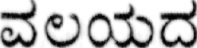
ವಲಯದ
